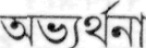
অভ্যৰ্থনা
